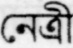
নেত্রী
